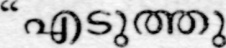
"എടുത്തു
